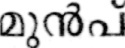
മുന്‍പ്
